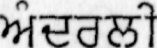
ਅੰਦਰਲੀ
